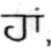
ਹਾਂ,
